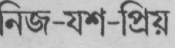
নিজ-যশ-প্ৰিয়
